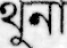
থুনা
